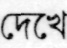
দেখে
